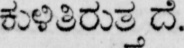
ಕುಳಿತಿರುತ್ತದೆ.
